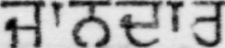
ਜਾਨਦਾਰ
